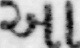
આ
